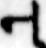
ન
